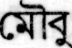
মৌবু
